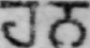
ਹਨ
